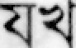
যখ
